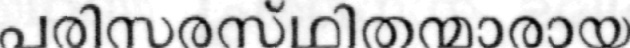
പരിസരസ്ഥിതന്മാരായ
